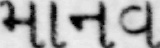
માનવ
